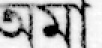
অমা
